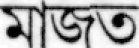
মাজত
